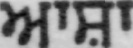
ਆਸ਼ਾ
